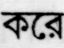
করে
